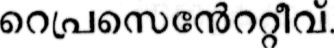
റെപ്രസെന്റേറ്റീവ്.
